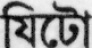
যিটো
